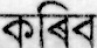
কৰিব
